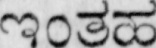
ಇಂತಹ
